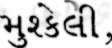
મુશ્કેલી,
